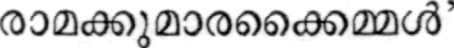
രാമക്കുമാരക്കൈമള്‍’
